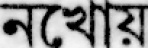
নখোয়
